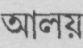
আলয়
